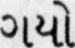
ગયો
